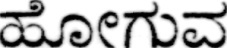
ಹೋಗುವ
